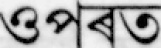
ওপৰত
